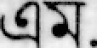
এম.
